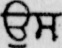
ਉਸ
